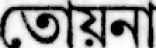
তোয়না
